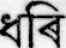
ধৰি
